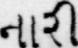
નારી
